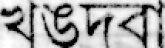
খঙদবা
